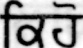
ਕਿਹੋ
